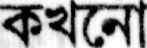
কখনো
